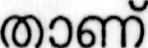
താണ്
